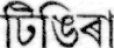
টিঙিৰা
